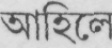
আহিলে
